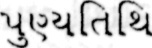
પુણ્યતિથિ
